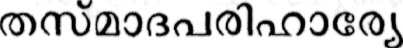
തസ്മാദപരിഹാര്യേ
